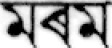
মৰম
